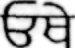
ਓਥੇ
